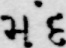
મંદ
